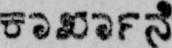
ಕಾರ್ಖಾನೆ
